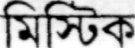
মিস্টিক
